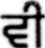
ਵੀ
